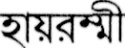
হায়রম্মী
